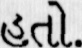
હતો.
